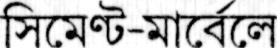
সিমেণ্ট-মার্বেলে
